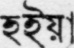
হইয়া
